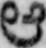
ಆ
